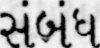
સંબંધ
